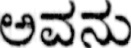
ಅವನು
